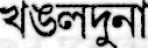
খঙলদুনা
